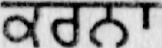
ਕਰਨਾ
